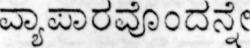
ವ್ಯಾಪಾರವೊಂದನ್ನೇ
